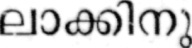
ലാക്കിനു
